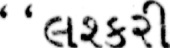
"લશ્કરી
